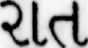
રાત
